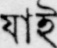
যাই
